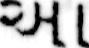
આ
